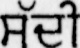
ਸੱਦੀ
